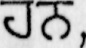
ਹਨ,
